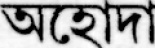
অহোদা
